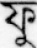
ফু
